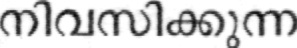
നിവസിക്കുന്ന
